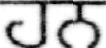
ਹਨ
